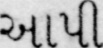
આપી
